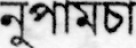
নুপামচা
